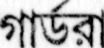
গার্ডরা
